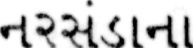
નરસંડાના
